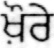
ਖ਼ੌਰੇ
